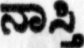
ನಾಸ್ತಿ
